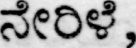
ನೇರಿಳೆ,
